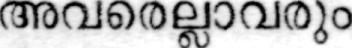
അവരെല്ലാവരും
